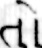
તો
